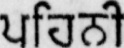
ਪਹਿਨੀ
